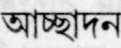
আচ্ছাদন
